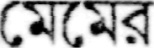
মেমের
